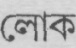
লোক
